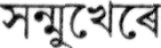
সন্মুখেৰে
